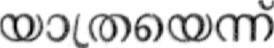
യാത്രയെന്ന്
